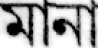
মানা
